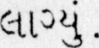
લાગ્યું.
